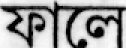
ফালে
